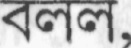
বলল,
